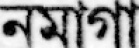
নমাগা
